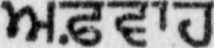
ਅਫ਼ਵਾਹ
